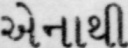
એનાથી
